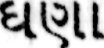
ઘણા
